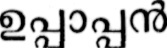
ഉപ്പാപ്പന്‍
